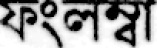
ফংলম্বা
